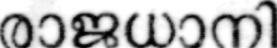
രാജധാനി
